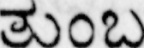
ತುಂಬ
